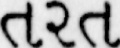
તરત
